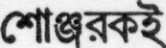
শোঞ্জরকই
